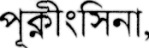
পূক্নীংসিনা,
